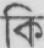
কি
